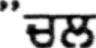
''ਚਲ
